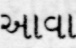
આવા
